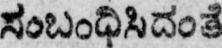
ಸಂಬಂಧಿಸಿದಂತೆ
